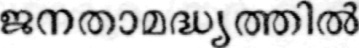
ജനതാമദ്ധ്യത്തില്‍
